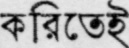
করিতেই
